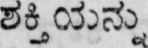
ಶಕ್ತಿಯನ್ನು
